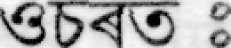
ওচৰতঃ
